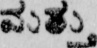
ಮತ್ತು
